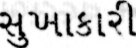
સુખાકારી
